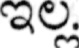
ಇಲ್ಲ.
